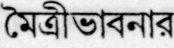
মৈত্রীভাবনার
